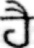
ਹੈ
